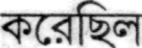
করেছিল
